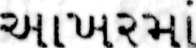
આખરમાં
